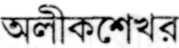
অলীকশেখর
